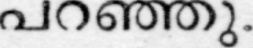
പറഞ്ഞു.
